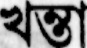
খন্তা
